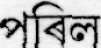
পৰিল
